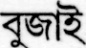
বুজাই
